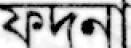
ফদনা
